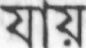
যায়
